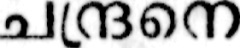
ചന്ദ്രനെ
